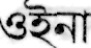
ওইনা
